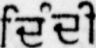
ਦਿੰਦੀ
